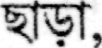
ছাড়া,
